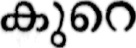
കുറെ
